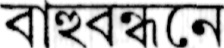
বাহুবন্ধনে
